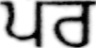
ਪਰ
